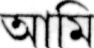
আমি
